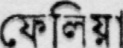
ফেলিয়া
